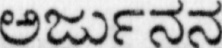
ಅರ್ಜುನನ
